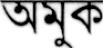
অমুক
